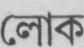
লোক
